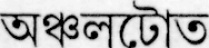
অঞ্চলটোত
